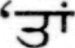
'ਤਾਂ
